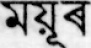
ময়ূৰ
